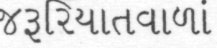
જરૂરિયાતવાળાં
